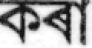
কৰা
